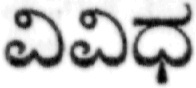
ವಿವಿಧ
